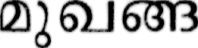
മുഖങ്ങ
